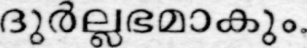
ദുര്‍ല്ലഭമാകും.
